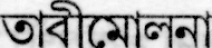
তাবীমোলনা
